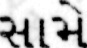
સામે
